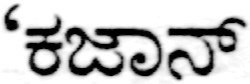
'ಕಜಾನ್
